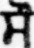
ਸੌ
